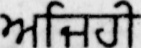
ਅਜਿਹੀ
